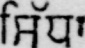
ਸਿੱਧਾ
